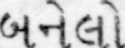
બનેલો
